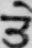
ਤੇ
